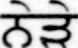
ਨੇੜੇ
